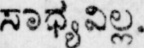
ಸಾಧ್ಯವಿಲ್ಲ.
